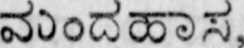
ಮಂದಹಾಸ,
